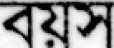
বয়স
